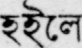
হইলে
